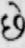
છે
